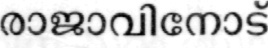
രാജാവിനോട്
